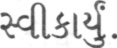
સ્વીકાર્યું.
